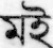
মই
